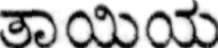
ತಾಯಿಯ
